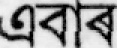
এবাৰ
